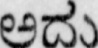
ಅದು
